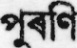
পুৰণি
